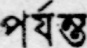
পর্যন্ত
